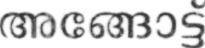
അങ്ങോട്ട്
